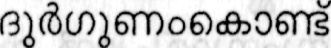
ദുര്‍ഗുണംകൊണ്ട്
